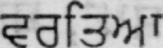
ਵਰਤਿਆ
